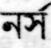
নর্স
